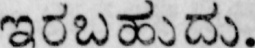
ಇರಬಹುದು.
